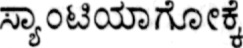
ಸ್ಯಾಂಟಿಯಾಗೋಕ್ಕೆ
